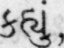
કહ્યું,
